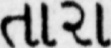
તારા
